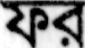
ফর
